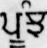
ਪੂੰਝ
